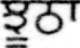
ਝੂਠਾ
